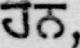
ਹਨ,
